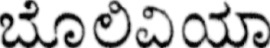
ಬೊಲಿವಿಯಾ
